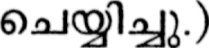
ചെയ്യിച്ചു.)
